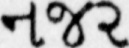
નજર
